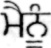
ਮੈਨੂੰ
